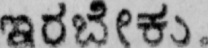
ಇರಬೇಕು.
